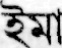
ইমা
